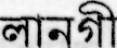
লানগী
